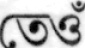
তেওঁ
